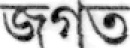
জগত
